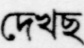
দেখছ
